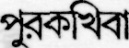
পুরকখিবা
